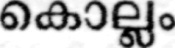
കൊല്ലം
